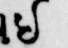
થઈ
